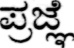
ಪ್ರಜ್ಞೆ
